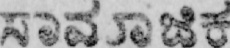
ಸಾಮಾಜಿಕ
